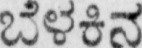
ಬೆಳಕಿನ
